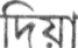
দিয়া
